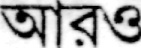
আরও
